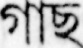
গাছ
